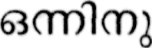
ഒന്നിനു
